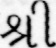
શ્રી
